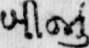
બીજું
